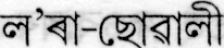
ল'ৰা-ছোৱালী
